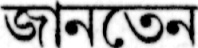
জানতেন
